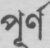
পূৰ্ণ
